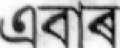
এবাৰ
